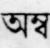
অম্ব
